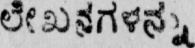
ಲೇಖನಗಳನ್ನು
